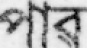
পাৱ
